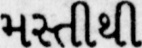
મસ્તીથી
